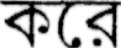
করে
